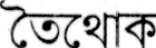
তৈথোক
